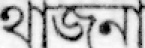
থাজনা
